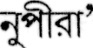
নুপীরা’
